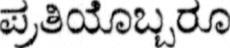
ಪ್ರತಿಯೊಬ್ಬರೂ
